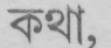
কথা,
